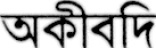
অকীবদি
